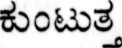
ಕುಂಟುತ್ತ
